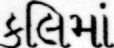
કલિમાં
